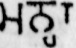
ਮਨ੍ਹਾ
